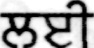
ਲਈ
